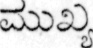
ಮುಖ್ಯ
